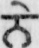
ਨੇ
